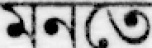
মনতে
